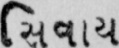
સિવાય
